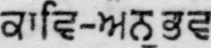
ਕਾਵਿ-ਅਨੁਭਵ
